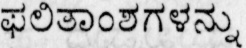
ಫಲಿತಾಂಶಗಳನ್ನು
